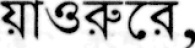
য়াওরুরে,
